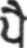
ਪੈ
